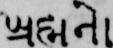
ખ્રહ્મનો
